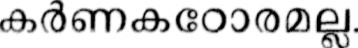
കര്‍ണകഠോരമല്ല.
